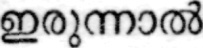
ഇരുന്നാല്‍
